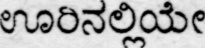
ಊರಿನಲ್ಲಿಯೇ
